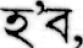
হ'ব,
